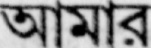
আমার
